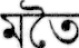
মতৈ
